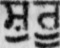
ਸ਼ੁਰੂ
